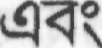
এবং
